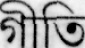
গীতি
